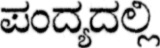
ಪಂದ್ಯದಲ್ಲಿ
